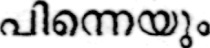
പിന്നെയും
